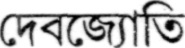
দেবজ্যোতি
